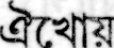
ঐখোয়
